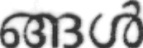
ങ്ങള്‍
